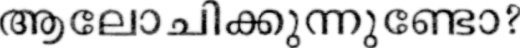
ആലോചിക്കുന്നുണ്ടോ?
